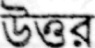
উত্তর
